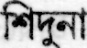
শিদুনা
